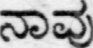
ನಾವು
